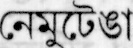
নেমুটেঙা
